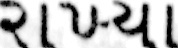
રાખ્યા
